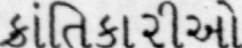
ક્રાંતિકારીઓ
